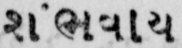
શંભવાય
